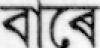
বাৰে
